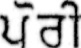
ਪੋਰੀ
